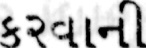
કરવાની
